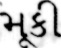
મૂકી
